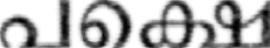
പക്ഷെ
